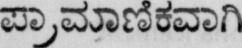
ಪ್ರಾಮಾಣಿಕವಾಗಿ
